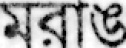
মরাঙ
